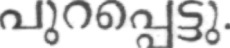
പുറപ്പെട്ടു.
